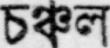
চঞ্চল
